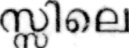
സ്സിലെ
